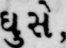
ઘુસે,
